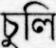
চুলি
